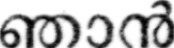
ഞാന്‍
